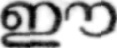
ഈ
